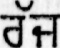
ਰੱਜ
